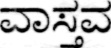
ವಾಸ್ತವ
